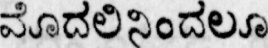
ಮೊದಲಿನಿಂದಲೂ
